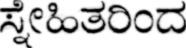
ಸ್ನೇಹಿತರಿಂದ
